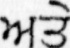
ਅਤੇ
